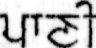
ਪਾਣੀ
